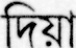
দিয়া
